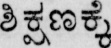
ಶಿಕ್ಷಣಕ್ಕೆ
